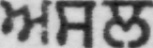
ਅਸਲ
